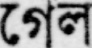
গেল
